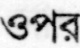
ওপর
